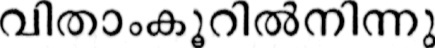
വിതാംകൂറില്‍നിന്നു
